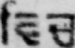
ਵਿਚ
